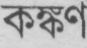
কঙ্কণ
